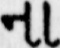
ના
